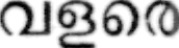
വളരെ
